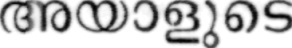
അയാളുടെ
